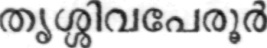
തൃശ്ശിവപേരൂര്‍
